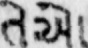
તેઓ
